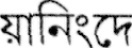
য়ানিংদে
